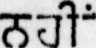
ਨਹੀਂ
